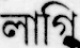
লাগি
